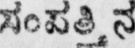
ಸ೦ಪತ್ತಿನ
